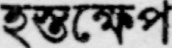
হস্তক্ষেপ
